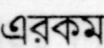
এরকম
